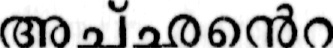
അച്ഛന്റെ
